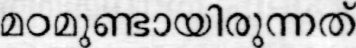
മഠമുണ്ടായിരുന്നത്
